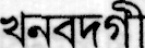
খনবদগী
